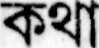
কথা
